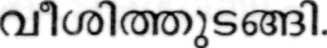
വീശിത്തുടങ്ങി.
